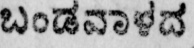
ಬಂಡವಾಳದ
